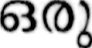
ഒരു
